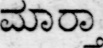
ಮಾರ್‍ತಾ
